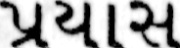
પ્રયાસ
